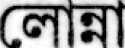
লোন্না
